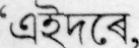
'এইদৰে,
